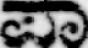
ಪಾ
